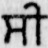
ਸੀ
